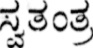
ಸ್ವತಂತ್ರ
